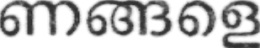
ണങ്ങളെ
